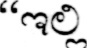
"ಇಲ್ಲಿ
